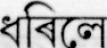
ধৰিলে
